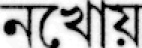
নখোয়
